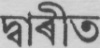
দ্বাৰীত
